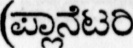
(ಪ್ಲಾನೆಟರಿ
